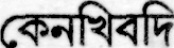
কেনখিবদি
